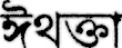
ঈথক্তা
